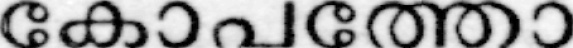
കോപത്തോ
